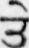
ਤੇ
